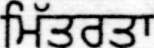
ਮਿੱਤਰਤਾ
